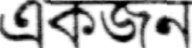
একজন
